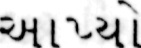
આપ્યો
